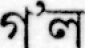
গ'ল
